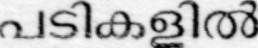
പടികളില്‍
